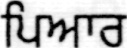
ਪਿਆਰ
